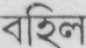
বহিল
